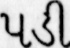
પડી
